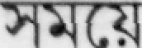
সময়ে
